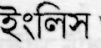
ইংলিস
